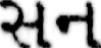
સન
